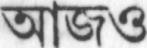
আজও
